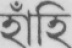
হাঁহি
